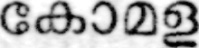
കോമള
